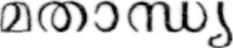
മതാന്ധ്യ
